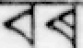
বৰ
